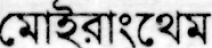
মোইরামথেম
